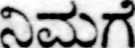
ನಿಮಗೆ
